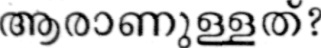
ആരാണുള്ളത്?
